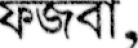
ফজবা,
